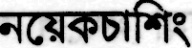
নয়েকচাশিং
